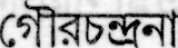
গৌরচন্দ্রনা
